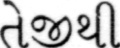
તેજીથી
